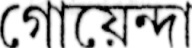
গোয়েন্দা
